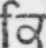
ਕਿ
